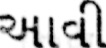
આવી
